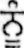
ਨੂੰ
